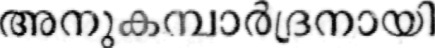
അനുകമ്പാര്‍ദ്രനായി
